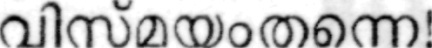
വിസ്മയംതന്നെ!
